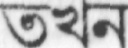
তখন
